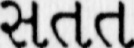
સતત
